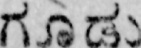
ಗೂಡು
